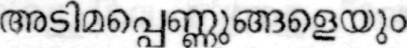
അടിമപ്പെണ്ണുങ്ങളെയും
